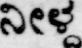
ನೀಳ್ದ
